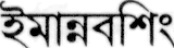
ইমান্নবশিং
